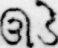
ઊડે
